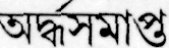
অর্দ্ধসমাপ্ত
